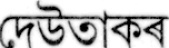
দেউতাকৰ
